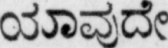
ಯಾವುದೇ
